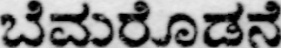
ಬೆಮರೊಡನೆ
